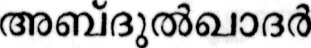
അബ്ദുല്‍ഖാദര്‍
